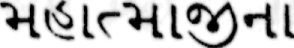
મહાત્માજીના
